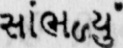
સાંભળ્યું
